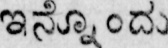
ಇನ್ನೊಂದು
